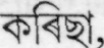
কৰিছা,
